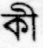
কী
